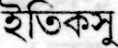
ইতিকসু
